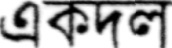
একদল
